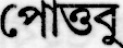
পোত্তবু
